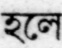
হলে
